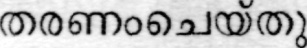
തരണംചെയ്തു
